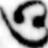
ও
